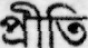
প্রীতি
